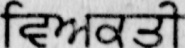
ਵਿਅਕਤੀ
